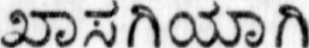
ಖಾಸಗಿಯಾಗಿ
